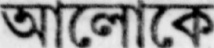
আলোকে
